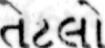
તેટલો
